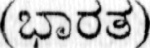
(ಭಾರತ)
